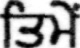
ਤਿਮੇਂ
